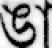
ঙা
